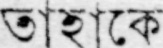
তাহাকে
